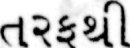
તરફથી
